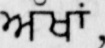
ਅੱਖਾਂ,
